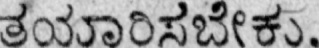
ತಯಾರಿಸಬೇಕು.
